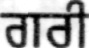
ਗਰੀ
